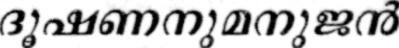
ദൂഷണനുമനുജന്‍
